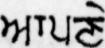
ਆਪਣੇ
